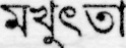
মখুৎতা
